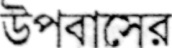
উপবাসের
